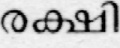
രക്ഷി
